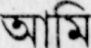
আমি
